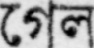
গেল
